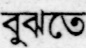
বুঝতে
